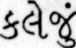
કલેજું
